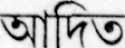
আদিত
